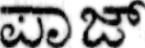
ಪಾಜ್
